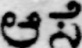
ಆಸೆ
